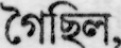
গৈছিল,
